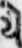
યે
